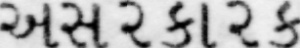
અસરકારક
